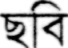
ছবি
